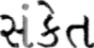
સંકેત
